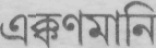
এক্কণমানি
